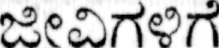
ಜೀವಿಗಳಿಗೆ
